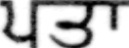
ਪਤਾ
